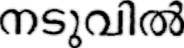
നടുവില്‍
